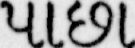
પાછા
